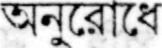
অনুরোধে
